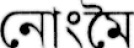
নোংমৈ
